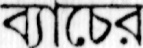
ব্যাচের
